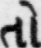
તો
